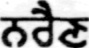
ਨਰੈਣ
